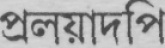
প্ৰলয়াদপি
